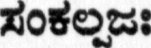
ಸಂಕಲ್ಪಜಃ
